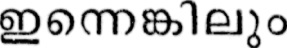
ഇന്നെങ്കിലും
